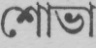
শোভা
